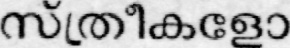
സ്ത്രീകളോ
